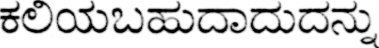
ಕಲಿಯಬಹುದಾದುದನ್ನು
